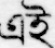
এই
